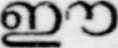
ഈ
